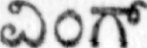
ವಿಂಗ್
